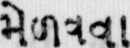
મેળવવા
